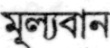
মূল্যবান
